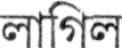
লাগিল
